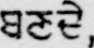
ਬਣਦੇ,
